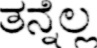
ತನ್ನೆಲ್ಲ
